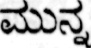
ಮುನ್ನ
